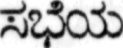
ಸಭೆಯ
